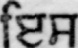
ਇਸ
